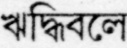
ঋদ্ধিবলে
